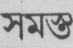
সমস্ত
